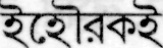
ইহৌরকই
